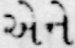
એને
